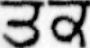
ਤਕ
